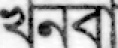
খনবা
